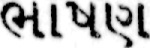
ભાષણ
